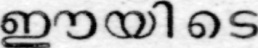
ഈയിടെ
